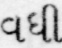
વધી
